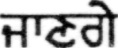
ਜਾਣਗੇ
